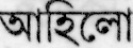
আহিলো
